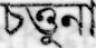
চত্তুনা
